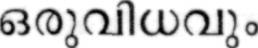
ഒരുവിധവും
